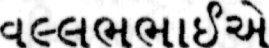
વલ્લભભાઈએ
